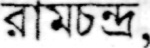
রামচন্দ্র,
